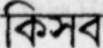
কিসব
